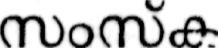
സംസ്ക
